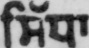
ਸਿੱਧਾ
